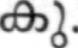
കു.
